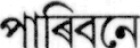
পাৰিবনে
